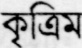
কৃত্রিম
